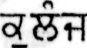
ਕੁਲੰਜ
